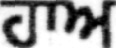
ਹਾਅ
